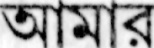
আমার
